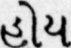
હોય
